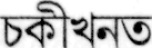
চকীখনত
